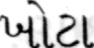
ખોટા
